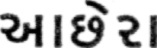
આછેરા
